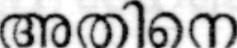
അതിനെ
